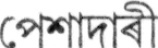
পেশাদাৰী
